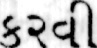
કરવી
